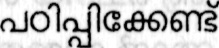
പഠിപ്പിക്കേണ്ട്
